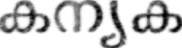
കന്യക
